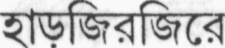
হাড়জিরজিরে
